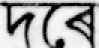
দৰে
